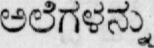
ಅಲೆಗಳನ್ನು
